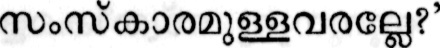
സംസ്കാരമുള്ളവരല്ലേ?'
